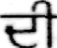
ਦੀ
